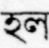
হল
